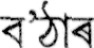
ব'ঠাৰ
